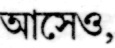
আসেও,
